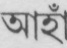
আহাঁ
